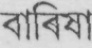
বাৰিষা
